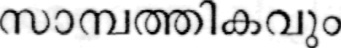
സാമ്പത്തികവും
